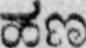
ಹಣ
